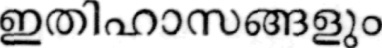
ഇതിഹാസങ്ങളും
